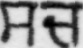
ਸਚ
